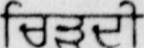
ਚਿੜਦੀ
